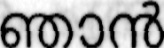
ഞാന്‍
